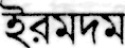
ইরমদম
